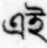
এই
